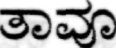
ತಾವೂ
